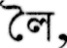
লৈ,
